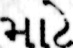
માટે
